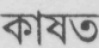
কাষত
